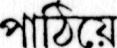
পাঠিয়ে
